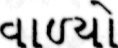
વાળ્યો
